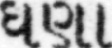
ઘણા
